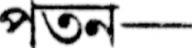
পতন-
